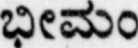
ಭೀಮಂ
